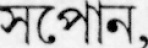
সপোন,
